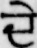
ਦੇ
